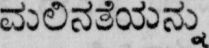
ಮಲಿನತೆಯನ್ನು
